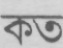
কত
